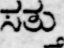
ಸತ್ತು
